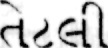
ત્યારે
